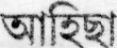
আহিছা
